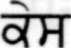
ਕੇਸ
